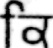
ਕਿ
